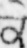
ਕੇ
